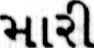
મારી
